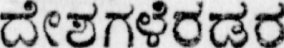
ದೇಶಗಳೆರಡರ
